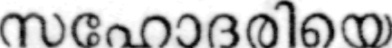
സഹോദരിയെ
